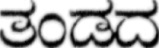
ತಂಡದ
